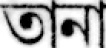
তানা
